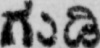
ಗುಡಿ
